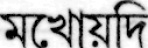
মখোয়দি
